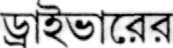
ড্রাইভারের
